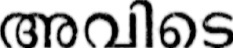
അവിടെ
